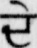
ਦੇ
